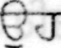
ਉਹ
